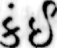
કંઈ
